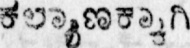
ಕಲ್ಯಾಣಕ್ಕಾಗಿ
